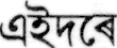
এইদৰে
